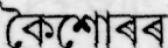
কৈশোৰৰ
